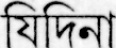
যিদিনা
